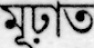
মূঢ়াত
